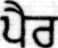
ਪੈਰ
